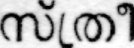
സ്ത്രീ
